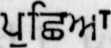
ਪੁਛਿਆ
